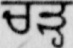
ਚੜ੍ਹ
